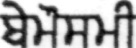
ਬੇਮੌਸਮੀ
